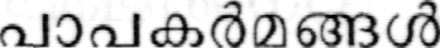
പാപകര്‍മങ്ങള്‍
